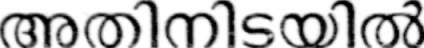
അതിനിടയില്‍
